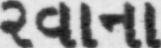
રવાના
